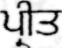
ਪ੍ਰੀਤ
